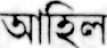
আহিল
